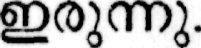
ഇരുന്നു.
